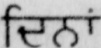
ਦਿਨਾਂ
